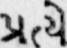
પ્રત્યે
